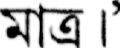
মাত্র।'
